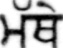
ਮੱਥੇ
